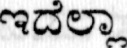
ಇದೆಲ್ಲಾ
